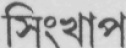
সিংখাপ
